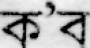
ক'ব
